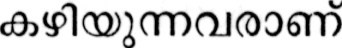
കഴിയുന്നവരാണ്
